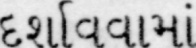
દર્શાવવામાં
